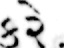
કરે.
